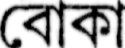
বোকা
